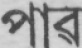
পাৱ
